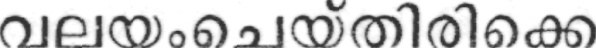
വലയംചെയ്തിരിക്കെ
